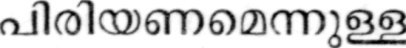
പിരിയണമെന്നുള്ള
